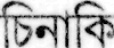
চিনাকি
